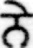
ਨੇ
